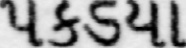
પકડ્યા
